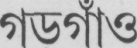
গড়গাওঁ
